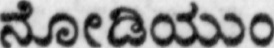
ನೋಡಿಯುಂ
